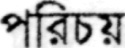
পরিচয়
